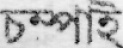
চম্পাই
